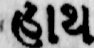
હાથ
